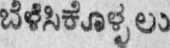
ಬೆಳೆಸಿಕೊಳ್ಳಲು
